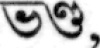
ভণ্ড,
